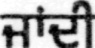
ਜਾਂਦੀ
